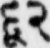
દૂર
